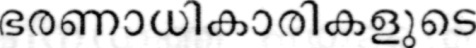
ഭരണാധികാരികളുടെ
